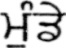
ਮੁੰਡੇ
